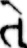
તે
